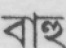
বাহু
